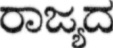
ರಾಜ್ಯದ
